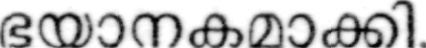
ഭയാനകമാക്കി.
